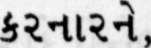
કરનારને,
